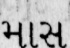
માસ
